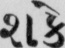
શકે
